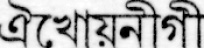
ঐখোয়নীগী
